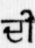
ਦੀ
